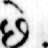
છે.
